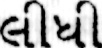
લીધી
